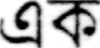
এক
